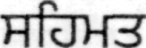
ਸਹਿਮਤ
